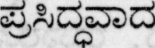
ಪ್ರಸಿದ್ಧವಾದ
